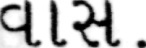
વાસ.
